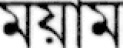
ময়াম
